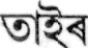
তাইৰ
